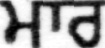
ਮਾਰ
